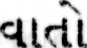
વાતો
